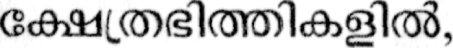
ക്ഷേത്രഭിത്തികളില്‍,
